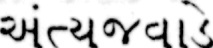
અંત્યજવાડે
